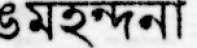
ঙমহন্দনা
